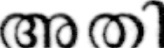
അതി
